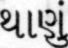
થાણું
